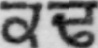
ਕਢ
